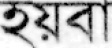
হায়বা
